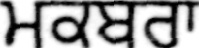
ਮਕਬਰਾ
